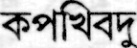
কপখিবদু
